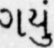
ગયું
